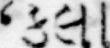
'કલા
